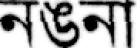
নঙনা
